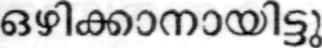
ഒഴിക്കാനായിട്ടു
